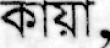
কায়া,
